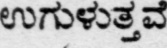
ಉಗುಳುತ್ತವೆ
